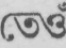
তেওঁ
